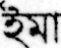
ইমা
